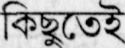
কিছুতেই
